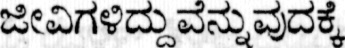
ಜೀವಿಗಳಿದ್ದುವೆನ್ನುವುದಕ್ಕೆ
